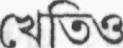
খেতিও
